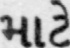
માટે
